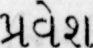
પ્રવેશ
